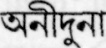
অনীদুনা
